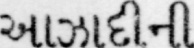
આઝાદીની
